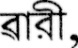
ৱারী,
